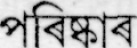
পৰিষ্কাৰ
